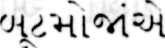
બૂટમોજાંએ
